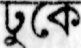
ঢুকে
